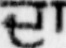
ਦਾ
